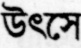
উত্সে
